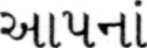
આપનાં
